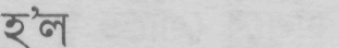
হ'ল
